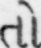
તો
